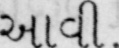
આવી.
